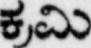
ಕ್ರಮಿ
